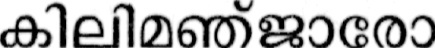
കിലിമഞ്ജാരോ
